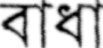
বাধা
